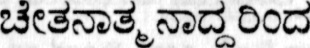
ಚೇತನಾತ್ಮನಾದ್ದರಿಂದ
